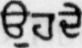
ਉਹਦੇ
